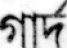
গার্দ
